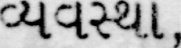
વ્યવસ્થા,
